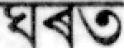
ঘৰত
